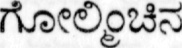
ಗೋಲ್ಮಿಂಚಿನ
